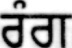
ਰੰਗ
